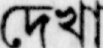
দেখা
